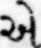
એ
